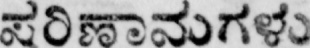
ಪರಿಣಾಮಗಳು
